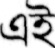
এই
